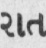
રાત
